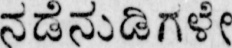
ನಡೆನುಡಿಗಳೇ
